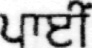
ਪਾਈਂ
